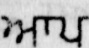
ਆਪ
